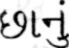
છાનું
